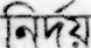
নির্দয়
